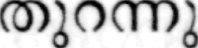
തുറന്നു
